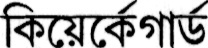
কিয়ের্কেগার্ড
